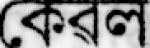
কেৱল
